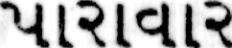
પારાવાર
